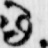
છે,
